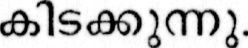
കിടക്കുന്നു.
